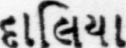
દાલિયા
